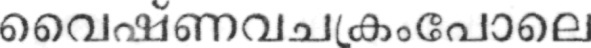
വൈഷ്ണവചക്രംപോലെ
